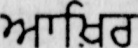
ਆਖ਼ਿਰ
